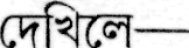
দেখিলে-
